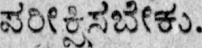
ಪರೀಕ್ಷಿಸಬೇಕು.
